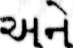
અને
